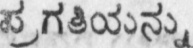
ಪ್ರಗತಿಯನ್ನು
